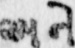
અને
